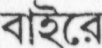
বাইরে
